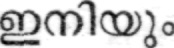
ഇനിയും
